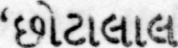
'છોટાલાલ
